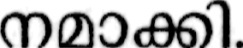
നമാക്കി.
